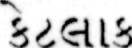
કેટલાક
